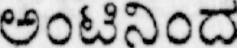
ಅಂಟಿನಿಂದ
